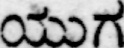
ಯುಗ
